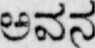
ಅವನ
